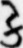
કે
